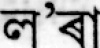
ল'ৰা
